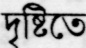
দৃষ্টিতে
